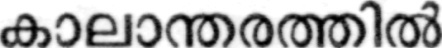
കാലാന്തരത്തില്‍
